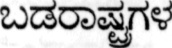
ಬಡರಾಷ್ಟ್ರಗಳ
